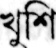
খুশি
